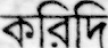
করিদি
